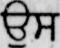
ਉਸ
